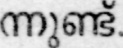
ന്നുണ്ട്.
